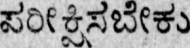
ಪರೀಕ್ಷಿಸಬೇಕು
